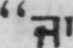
''ਜਾ
